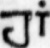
ਹਾਂ
